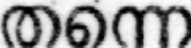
തന്നെ
